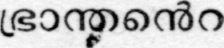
ഭ്രാന്തന്റെ
